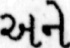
અને
